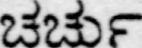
ಚರ್ಚು
